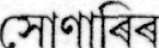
সোণাৰিৰ
